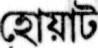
হোয়াট
